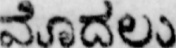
ಮೊದಲು
